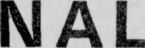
NAL
